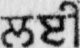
ਲਈ
